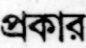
প্রকার
